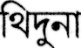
থিদুনা
